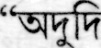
“অদুদি
